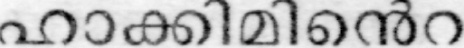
ഹാക്കിമിന്റെ
